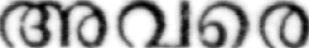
അവരെ
